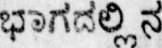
ಭಾಗದಲ್ಲಿನ
